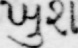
ખુશ
